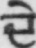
ਦੇ
